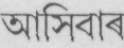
আসিবাৰ
